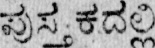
ಪುಸ್ತಕದಲ್ಲಿ
